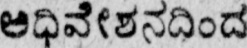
ಅಧಿವೇಶನದಿಂದ
